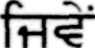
ਜਿਵੇਂ
